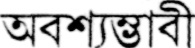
অবশ্যম্ভাবী
